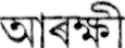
আৰক্ষী
